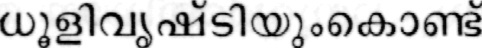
ധൂളിവൃഷ്ടിയുംകൊണ്ട്
